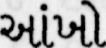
આંખો
